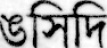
ঙসিদি
